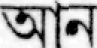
আন
